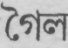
গৈল
